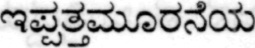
ಇಪ್ಪತ್ತಮೂರನೆಯ
